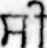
ਸੀ
